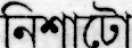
নিশাটো
